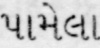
પામેલા
